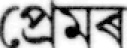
প্রেমৰ
